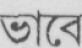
ভাবে
